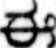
ಈ
